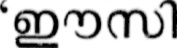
‘ഈസി
